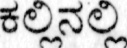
ಕಲ್ಲಿನಲ್ಲಿ
